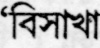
‘বিসাখা
